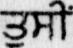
ਤੁਸੀਂ
